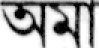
অমা
